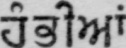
ਹੰਭੀਆਂ
